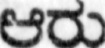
ಆರು
